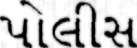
પોલીસ
